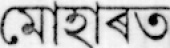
মোহাৰত
